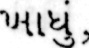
ખાધું,
